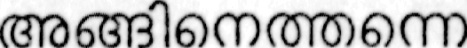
അങ്ങിനെത്തന്നെ
